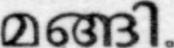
മങ്ങി.
